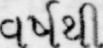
વર્ષથી
